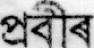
প্রবীৰ
